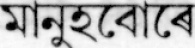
মানুহবোৰে
